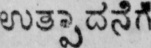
ಉತ್ಪಾದನೆಗೆ
